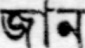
জান
